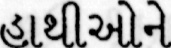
હાથીઓને
